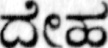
ದೇಹ
